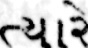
ત્યારે
